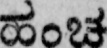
ಹಂಚ
